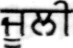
ਜੂਲੀ
